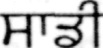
ਸਾਡੀ
